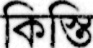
কিস্তি
